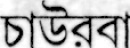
চাউরবা
